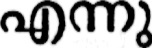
എന്നു
